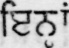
ਇਨ੍ਹਾਂ
